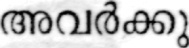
അവര്‍ക്കു
